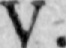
V.
